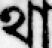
থা
